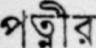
পত্নীর
